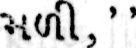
મળી,"
